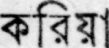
করিয়া
